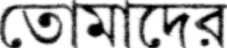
তোমাদের
